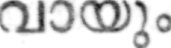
വായും
